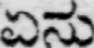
ಏನು
